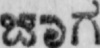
ಜಾಗ
